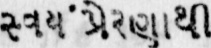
સ્વયંપ્રેરણાથી
